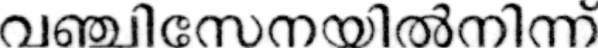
വഞ്ചിസേനയില്‍നിന്ന്
